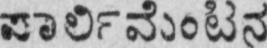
ಪಾರ್ಲಿಮೆಂಟಿನ
